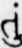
તું
